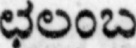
ಛಲಂಬ
